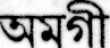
অমগী
